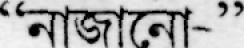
"নাজানো-"
